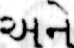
અને
